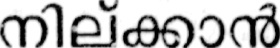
നില്ക്കാന്‍
